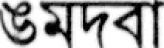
ঙমদবা
